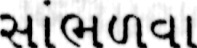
સાંભળવા
